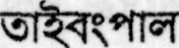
তাইবংপাল
